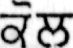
ਕੋਲ
